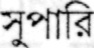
সুপারি
